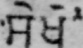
ਸੇਖੋਂ
